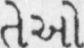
તેઓ
